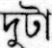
দুটা
